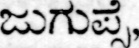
ಜುಗುಪ್ಸೆ,
